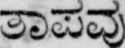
ತಾಪವು
